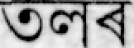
তলৰ
